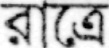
রাত্রে
